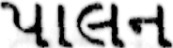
પાલન
